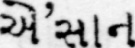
એ'સાન
